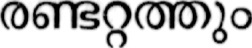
രണ്ടറ്റത്തും
